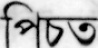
পিচত
